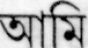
আমি
